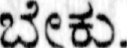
ಬೇಕು.
